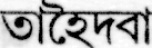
তাহৈদবা
